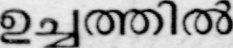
ഉച്ചത്തില്‍
